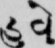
હવે
